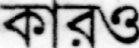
কারও
